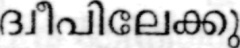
ദ്വീപിലേക്കു
